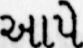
આપે
